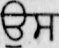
ਉਸ
